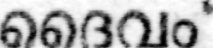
ദൈവം'
